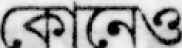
কোনেও
